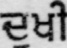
ਦੁਖੀ
